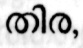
തിര,
